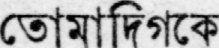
তোমাদিগকে
